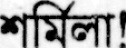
শর্মিলা!
